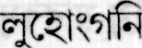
লুহোংগনি
